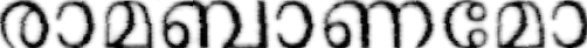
രാമബാണമോ
